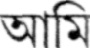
আমি
